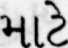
માટે
